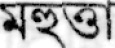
মহুত্তা
